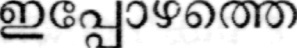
ഇപ്പോഴത്തെ
